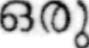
ഒരു
